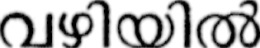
വഴിയില്‍
